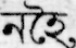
নহৈ,
